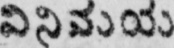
ವಿನಿಮಯ
